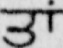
ਤਾਂ
